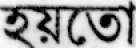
হয়তো
